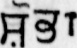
ਸ਼ੋਭਾ
